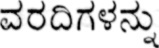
ವರದಿಗಳನ್ನು
